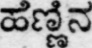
ಹೆಣ್ಣಿನ
